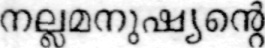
നല്ലമനുഷ്യന്റെ
